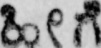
ಹೀಗೆ
